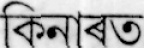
কিনাৰত
